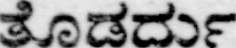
ತೊಡರ್ದು
